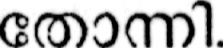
തോന്നി.
